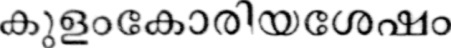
കുളംകോരിയശേഷം
